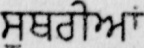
ਸੁਥਰੀਆਂ
